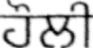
ਹੌਲੀ
